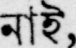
নাই,
